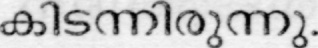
കിടന്നിരുന്നു.
